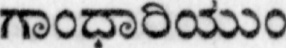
ಗಾಂಧಾರಿಯುಂ
